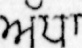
ਅੱਧਾ
